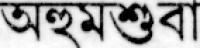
অহুমশুবা
